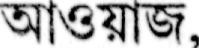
আওয়াজ,
